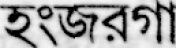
হংজরগা
